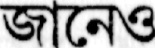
জানেও
